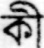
কী
